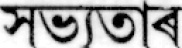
সভ্যতাৰ
